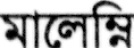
মালেম্নি
